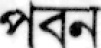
পবন
